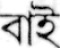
বাই
